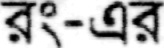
রং-এর
